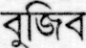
বুজিব
